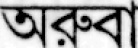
অরুবা
